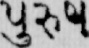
પુરુષ
